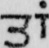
ਤਾਂ
